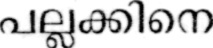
പല്ലക്കിനെ
